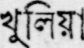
খুলিয়া
